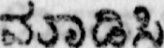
ಮಾಡಿಸಿ
